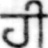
ਹੀ
